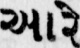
આરે
